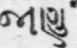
જાણું
